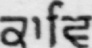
ਕਾਵਿ
